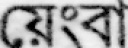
য়েংবা
